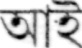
আই
